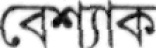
বেশ্যাক
